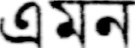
এমন
